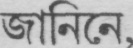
জানিনে,
